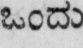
ಒಂದು
